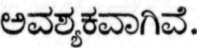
ಅವಶ್ಯಕವಾಗಿವೆ.
